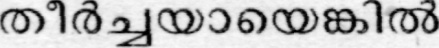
തീര്‍ച്ചയായെങ്കില്‍
